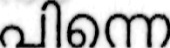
പിന്നെ
